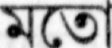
মতো
